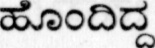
ಹೊಂದಿದ್ದ
